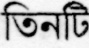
তিনটি
